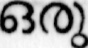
ഒരു
